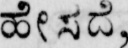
ಹೇಸದೆ,
